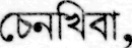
চেনখিবা,
